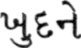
ખુદને
